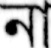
না
